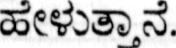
ಹೇಳುತ್ತಾನೆ.
